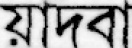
য়াদবা
